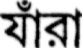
যাঁরা
